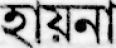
হায়না
